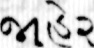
જાહેર
